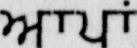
ਆਪਾਂ
